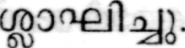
ശ്ലാഘിച്ചു.
